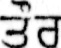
ਤੌਰ
